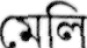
মেলি
